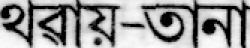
থৱায়-তানা
